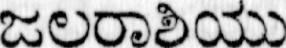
ಜಲರಾಶಿಯು
